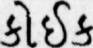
કોઈક
